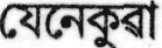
যেনেকুৱা
